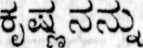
ಕೃಷ್ಣನನ್ನು
